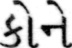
કોને
